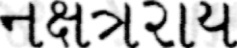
નક્ષત્રરાય
